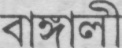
বাঙ্গালী
